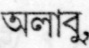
অলাবু,
